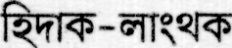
হিদাক-লাংথক
